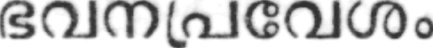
ഭവനപ്രവേശം
